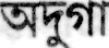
অদুগা
